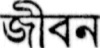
জীবন
